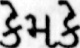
કેમકે
